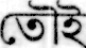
তৌই
